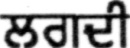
ਲਗਦੀ
